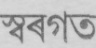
স্বৰগত
